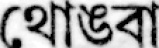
থোঙবা
